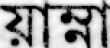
য়াম্না
